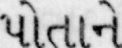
પોતાને
